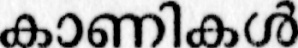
കാണികള്‍
